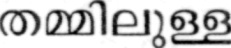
തമ്മിലുള്ള
